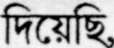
দিয়েছি,
